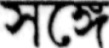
সঙ্গে
